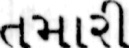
તમારી
